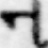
ન
